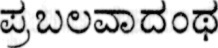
ಪ್ರಬಲವಾದಂಥ
